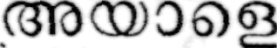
അയാളെ
